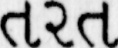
તરત
